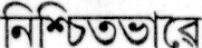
নিশ্চিতভাৱে
